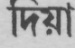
দিয়া
